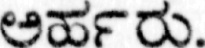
ಅರ್ಹರು.
